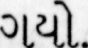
ગયો.
